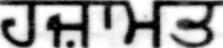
ਹਜ਼ਾਮਤ
